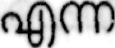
എന്ന
